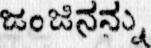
ಜಂಜಿನನ್ನು
